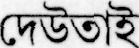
দেউতাই
